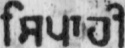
ਸਿਪਾਹੀ
